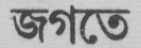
জগতে
